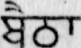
ਬੈਠਾ
